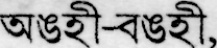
অঙহী-বঙহী,
